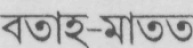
বতাহ-মাতত
